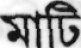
মাটি
